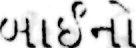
બાઈનો
